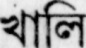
খালি
